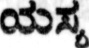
ಯಸ್ಯ
